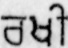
ਰਖੀ
